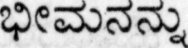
ಭೀಮನನ್ನು
